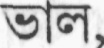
ভাল,
